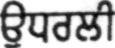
ਉਧਰਲੀ
